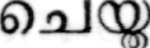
ചെയ്ത
